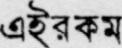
এইরকম
